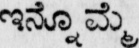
ಇನ್ನೊಮ್ಮೆ
